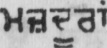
ਮਜ਼ਦੂਰਾਂ
